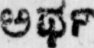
ಅರ್ಥ
